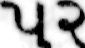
પર
